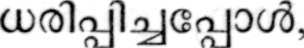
ധരിപ്പിച്ചപ്പോള്‍,
